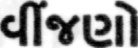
વીંજણો
